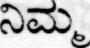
ನಿಮ್ಮ
